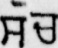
ਸੋਚ
